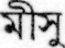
মীসু
